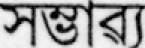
সম্ভাৱ্য
